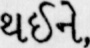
થઈને,
